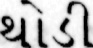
થોડી
